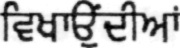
ਵਿਖਾਉਂਦੀਆਂ
